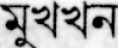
মুখখন
